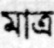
মাত্র
